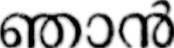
ഞാന്‍
